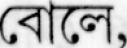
বোলে,
